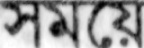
সময়ে
